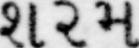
શરમ
